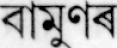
বামুণৰ
